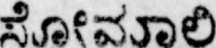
ಸೋಮಾಲಿ
